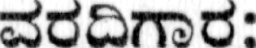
ವರದಿಗಾರ:
